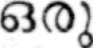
ഒരു
